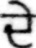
ਦੇ
